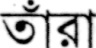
তাঁরা
